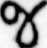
જ
